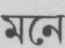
মনে
